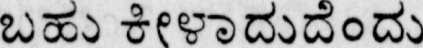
ಬಹುಕೀಳಾದುದೆಂದು
